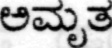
ಅಮೃತ
